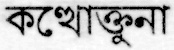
কত্থোক্তুনা
